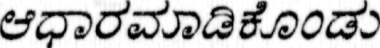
ಆಧಾರಮಾಡಿಕೊಂಡು
